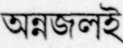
অন্নজলই
